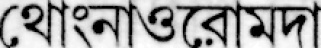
থোংনাওরোমদা
